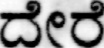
ದೇರೆ
